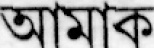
আমাক
